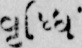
વૃધ્ધિં
